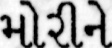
મોરીને
